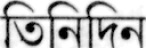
তিনিদিন
